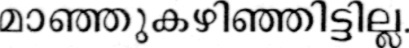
മാഞ്ഞുകഴിഞ്ഞിട്ടില്ല.
